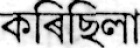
কৰিছিলা
